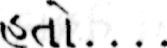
હતો....
